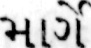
માર્ગે
